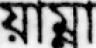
য়াম্ন
